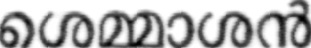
ശെമ്മാശന്‍
